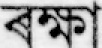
ৰক্ষা
